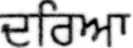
ਦਰਿਆ
